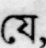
যে,
